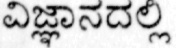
ವಿಜ್ಞಾನದಲ್ಲಿ
